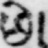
છો
